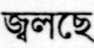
জ্বলছে
